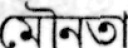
মৌনতা
